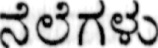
ನೆಲೆಗಳು
